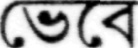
ভেবে
